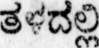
ತಳದಲ್ಲಿ
